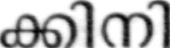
ക്കിനി
